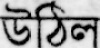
উঠিল
